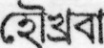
হৌখ্রবা
